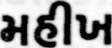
મહીખ
